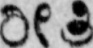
ರೀತಿ
